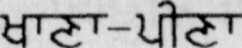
ਖਾਣਾ-ਪੀਣਾ
